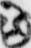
છે
